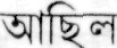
আছিল
